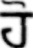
ਹੋ
